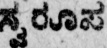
ಸ್ವರೂಪ
